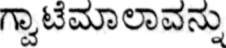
ಗ್ವಾಟೆಮಾಲಾವನ್ನು
